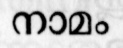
നാമം
